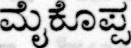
ಮೈಕೊಪ್ಪ
